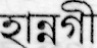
হান্নগী
